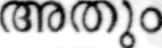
അതും
